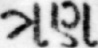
ત્રણ
